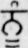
ਨੂੰ
